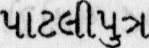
પાટલીપુત્ર
